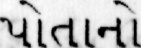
પોતાનો
